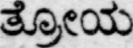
ತ್ರೋಯ
